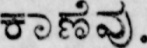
ಕಾಣೆವು.
